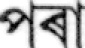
পৰা
